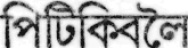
পিটিকিবলৈ
